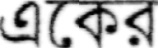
একের
